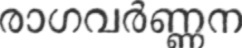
രാഗവര്‍ണ്ണന
